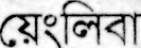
য়েংলিবা
